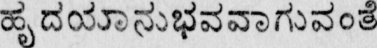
ಹೃದಯಾನುಭವವಾಗುವಂತೆ
